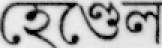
হেণ্ডেল
